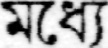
মধ্যে
